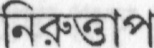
নিরুত্তাপ
